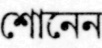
শোনেন
